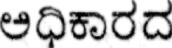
ಅಧಿಕಾರದ
